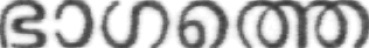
ഭാഗത്തെ
